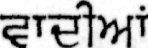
ਵਾਦੀਆਂ
